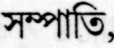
সম্পাতি,
